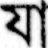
যা
